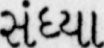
સંધ્યા
